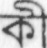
কী
